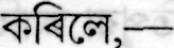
কৰিলে,-
